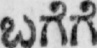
ಬಗೆಗೆ
